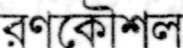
রণকৌশল
